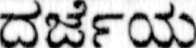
ದರ್ಜೆಯ
